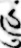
હું
